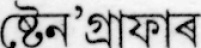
ষ্টেন'গ্রাফাৰ
